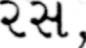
રસ,
